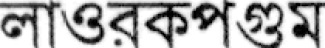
লাওরকপগুম
